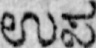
ಉಪ
